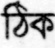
ঠিক
